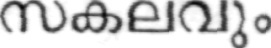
സകലവും
